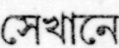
সেখানে
